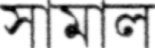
সামাল
